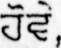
ਹੋਵੇ,
